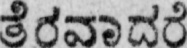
ತೆರವಾದರೆ
